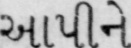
આપીને
